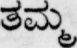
ತಮ್ಮ
